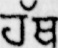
ਹੱਥ
